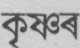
কৃষ্ণৰ
